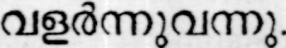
വളര്‍ന്നുവന്നു.
